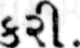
કરી.
